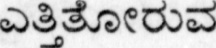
ಎತ್ತಿತೋರುವ
